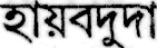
হায়বদুদা
